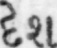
દેશ
